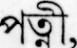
পত্নী,
